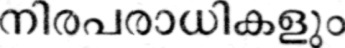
നിരപരാധികളും
